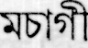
মচাগী
